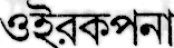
ওইরকপনা
